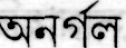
অনৰ্গল
